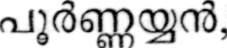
പൂര്‍ണ്ണയ്യന്‍,
